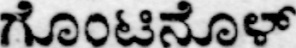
ಗೊಂಟಿನೊಳ್
